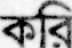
করি
